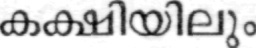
കക്ഷിയിലും
